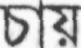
চায়
